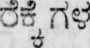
ರೆಕ್ಕೆಗಳ
